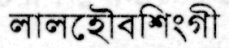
লালহৌবশিংগী
